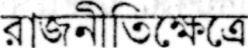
রাজনীতিক্ষেত্রে
